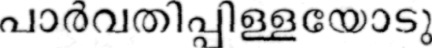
പാര്‍വതിപ്പിള്ളയോടു
